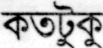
কতটুকু
